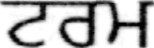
ਟਰਮ
